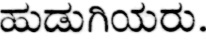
ಹುಡುಗಿಯರು.
